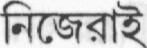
নিজেরাই
